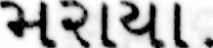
મરાયા.
